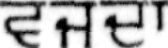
ਵਜਦਾ
